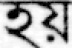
হয়
